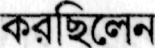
করছিলেন
